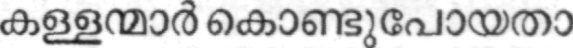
കള്ളന്മാര്‍കൊണ്ടുപോയതാ
